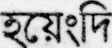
হয়েংদি
